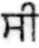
ਸੀ
